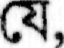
যে,
